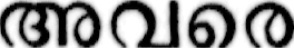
അവരെ
